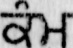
ਕੰਮ
